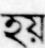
হয়
